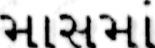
માસમાં
